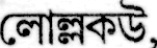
লোল্লকউ,
